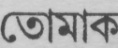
তোমাক
